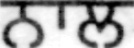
ਨਾਲ
